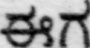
ಈಗ
